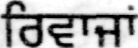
ਰਿਵਾਜਾਂ
